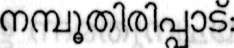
നമ്പൂതിരിപ്പാട്:
